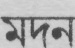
মদন
